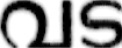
വട
